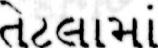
તેટલામાં
